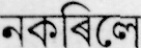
নকৰিলে
